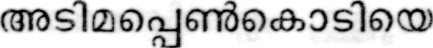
അടിമപ്പെണ്‍കൊടിയെ
